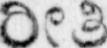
ರೀತಿ
